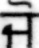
ਜੋ
